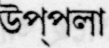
উপ্পলা
